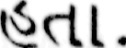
હતા.
